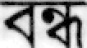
বন্ধ
